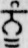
ਨੂੰ
